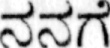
ನನಗೆ
